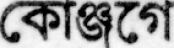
কোঞ্জগে
